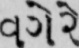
વગેરે
